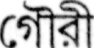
গৌরী
